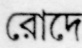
রোদে
